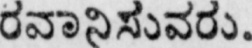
ರವಾನಿಸುವರು.
